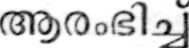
ആരംഭിച്ച്
